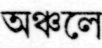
অঞ্চলে
